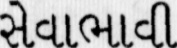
સેવાભાવી
